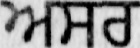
ਅਸਰ
